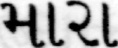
મારા
